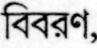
বিবরণ,
